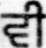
ਵੀ
